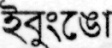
ইবুংঙো
